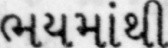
ભયમાંથી
